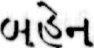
બહેન
